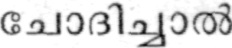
ചോദിച്ചാല്‍
